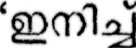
‘ഇനിച്ച്
